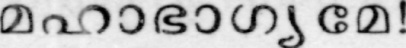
മഹാഭാഗ്യമേ!
